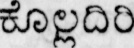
ಕೊಲ್ಲದಿರಿ
